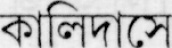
কালিদাসে
